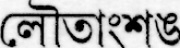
লৌতাংশঙ
